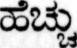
ಹೆಚ್ಚು
